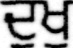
ਦੁਖੁ
